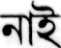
নাই
